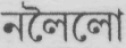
নলৈলো
